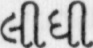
લીધી
